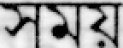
সময়
